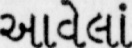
આવેલાં
